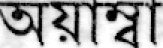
অয়াম্বা
